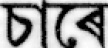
চাৰে
